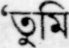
‘তুমি
